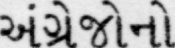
અંગ્રેજોનો
